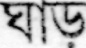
ঘাড়
